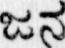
ಜನ
